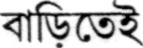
বাড়িতেই
